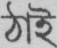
ঠাই
